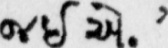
જઈએ.'
